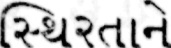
સ્થિરતાને
